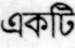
একটি
